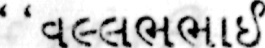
"વલ્લભભાઈ
